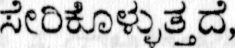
ಸೇರಿಕೊಳ್ಳುತ್ತದೆ,
